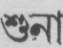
শুনা
